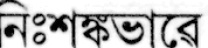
নিঃশঙ্কভাৱে
